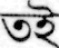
তই
